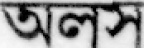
অলস
